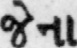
જેના
